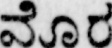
ಮೊರ
